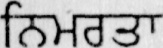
ਨਿਮਰਤਾ
